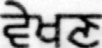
ਵੇਖਣ
